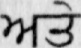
ਅਤੇ
